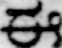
ಈ
